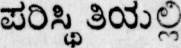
ಪರಿಸ್ಥಿತಿಯಲ್ಲಿ
